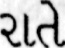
રાતે
